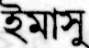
ইমাসু
